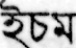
ইচম
